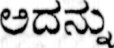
ಅದನ್ನು
